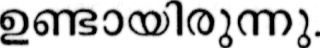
ഉണ്ടായിരുന്നു.
